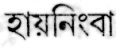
হায়নিংবা
